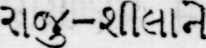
રાજુ-શીલાને
